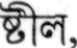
ষ্টীল,
